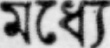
মধ্যে
